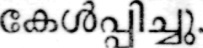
കേള്‍പ്പിച്ചു.
